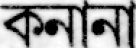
কনানা
